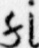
કાં
